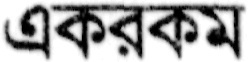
একরকম
